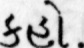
કહો.
